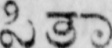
ಪಿತಾ
